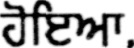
ਹੋਇਆ,
